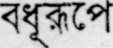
বধূরূপে
